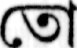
তো
